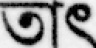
তাৎ
